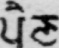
ਪੈਣ
